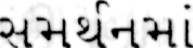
સમર્થનમાં
